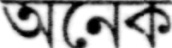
অনেক
